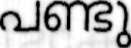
പണ്ടു
